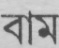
বাম
